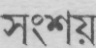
সংশয়
